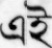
এই
